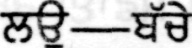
ਲਉ---ਬੱਚੇ
